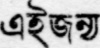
এইজন্য
